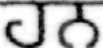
ਹਨ
